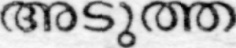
അടുത്ത
